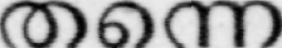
തന്നെ
